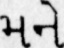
મને
